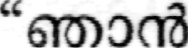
“ഞാന്‍
